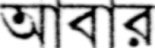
আবার
